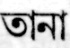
তানা
